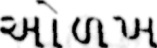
ઓળખ
